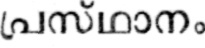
പ്രസ്ഥാനം
